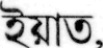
ইয়াত,
